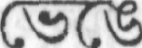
ভেঙে
